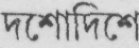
দশোদিশে
